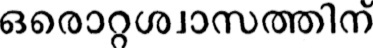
ഒരൊറ്റശ്വാസത്തിന്
